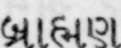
બ્રાહ્મણ
